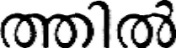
ത്തില്‍
